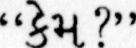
"કેમ?"
